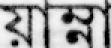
য়াম্না
